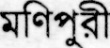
মণিপুরী
